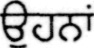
ਉਹਨਾਂ
